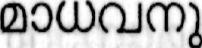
മാധവനു
